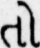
તો
